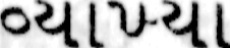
વ્યાખ્યા
